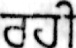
ਰਹੀ
